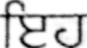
ਇਹ
